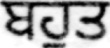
ਬਹੁਤ
